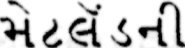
મેટલૅંડની
